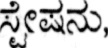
ಸ್ಟೇಷನು,
